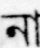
না
